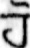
ਹੋ
